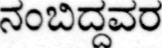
ನಂಬಿದ್ದವರ
